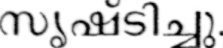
സൃഷ്ടിച്ചു.
